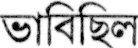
ভাবিছিল
